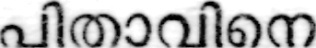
പിതാവിനെ
